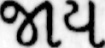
જાય
